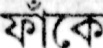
ফাঁকে
